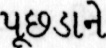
પૂછડાને
